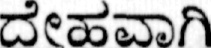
ದೇಹವಾಗಿ
